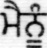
ਮੈਨੂੰ
